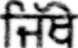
ਜਿੱਥੇ
